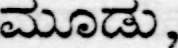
ಮೂಡು,
